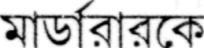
মার্ডারারকে
